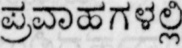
ಪ್ರವಾಹಗಳಲ್ಲಿ
